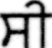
ਸੀ
